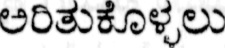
ಅರಿತುಕೊಳ್ಳಲು
